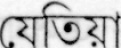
যেতিয়া
